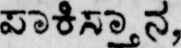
ಪಾಕಿಸ್ತಾನ,
